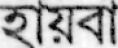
হায়বা
